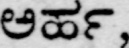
ಅರ್ಹ,
